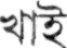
খাই
